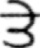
ਤੇ
